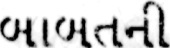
બાબતની
